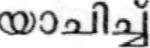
യാചിച്ച്
